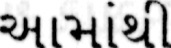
આમાંથી
